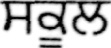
ਸਕੂਲ
